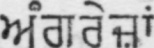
ਅੰਗਰੇਜ਼ਾਂ
